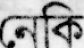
নেকি
